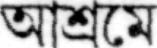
আশ্রমে
